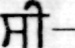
ਸੀ-
